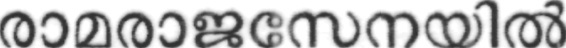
രാമരാജസേനയില്‍
